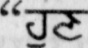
''ਹੁਣ
